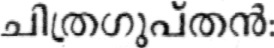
ചിത്രഗുപ്തന്‍:
